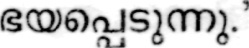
ഭയപ്പെടുന്നു.’
